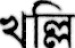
খল্লি
